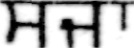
ਸਜਾ
